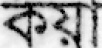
কয়া
